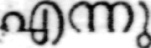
എന്നു
